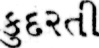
કુદરતી
